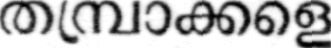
തമ്പ്രാക്കളെ
